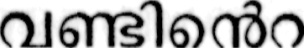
വണ്ടിന്റെ
